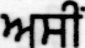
ਅਸੀਂ
